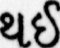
થઈ
